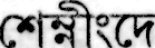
শেম্নীংদে
